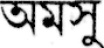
অমসু
